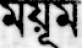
ময়ূম
